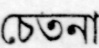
চেতনা
